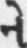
ને
